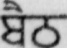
ਬੈਠ
